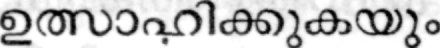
ഉത്സാഹിക്കുകയും
